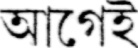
আগেই
